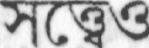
সত্ত্বেও
